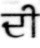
ਦੀ
